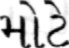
મોટે
